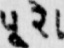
પૂરો
